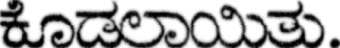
ಕೊಡಲಾಯಿತು.
